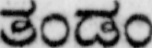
ತಂಡಂ
